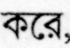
করে,
